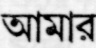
আমার
